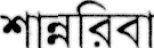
শান্নরিবা
